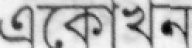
একোখন
